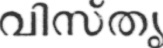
വിസ്തൃ
